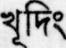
খূদিং
